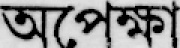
অপেক্ষা
